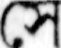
সে
